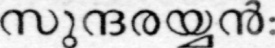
സുന്ദരയ്യന്‍:
